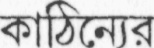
কাঠিন্যের
